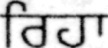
ਰਿਹਾ
